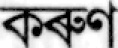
কৰুণ
